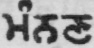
ਮੰਨਣ
